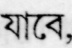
যাবে,
